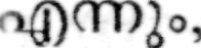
എന്നും,
